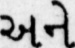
અને
